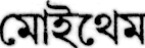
মোইথেম
